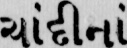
ચાંદીનાં
